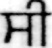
ਸੀ
